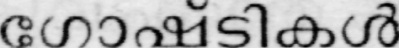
ഗോഷ്ടികള്‍
